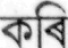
কৰি
